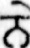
ਨੇ
